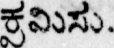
ಕ್ಷಮಿಸು.
